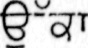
ਉੱਕਾ
